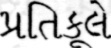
પ્રતિકૂલે
